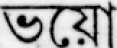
ভয়ো
